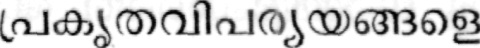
പ്രകൃതവിപര്യയങ്ങളെ
